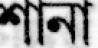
শানা
